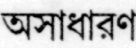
অসাধারণ
